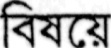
বিষয়ে
